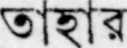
তাহার
